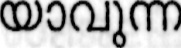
യാവുന്ന
